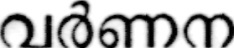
വര്‍ണന
